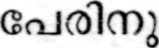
പേരിനു
